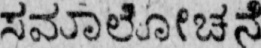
ಸಮಾಲೋಚನೆ
